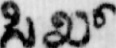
ಸಿಖ್
